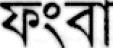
ফংবা
